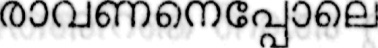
രാവണനെപ്പോലെ
